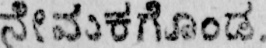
ನೇಮಕಗೊಂಡ.
